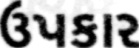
ઉપકાર
